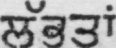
ਲੱਭਤਾਂ
